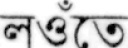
লওঁতে
